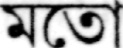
মতো
